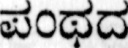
ಪಂಥದ
